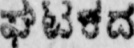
ಘಟಕದ
